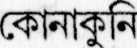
কোনাকুনি
